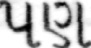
પણ
